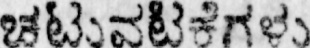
ಚಟುವಟಿಕೆಗಳು
